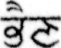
ਭੈਣ
